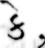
કે,
